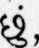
છું,
